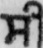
ਸੀ
